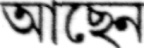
আছেন
